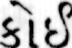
કોઈ
